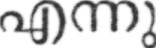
എന്നു
